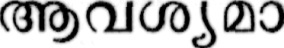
ആവശ്യമാ
